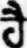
ਹੈ
